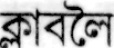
ক্লাবলৈ
